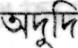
অদুদি
